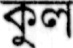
কুল
